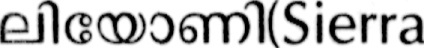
ലിയോണി(Sierra
